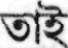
তাই
